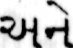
અને
